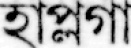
হাপ্লগা
